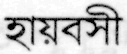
হায়বসী
